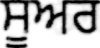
ਸੂਅਰ
